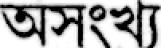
অসংখ্য
